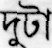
দুটা
